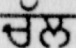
ਚੱਲ
